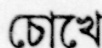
চোখে
